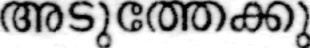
അടുത്തേക്കു
